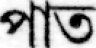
পাত
